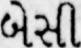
બેસી
